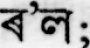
ৰ'ল;
